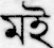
মই
